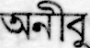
অনীবু
